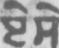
ਏਸੇ
